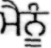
ਮੈਨੂੰ
